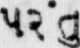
પરંતુ
